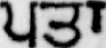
ਪਤਾ
